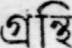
গ্রন্থি
